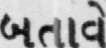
બતાવે
